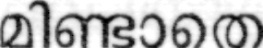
മിണ്ടാതെ
